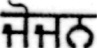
ਜੋਜਨ
